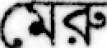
মেরু
